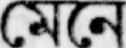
মেনে
